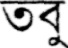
তবু
